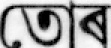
তোৰ
